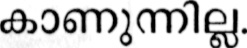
കാണുന്നില്ല.
